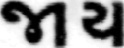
જાય
